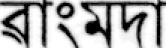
ৱাংমদা
